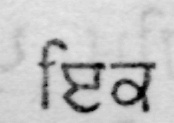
ਇਕ
